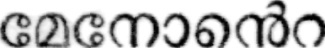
മേനോന്റെ
